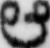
ಆ
